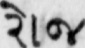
રોજ
